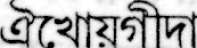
ঐখোয়গীদা
